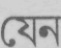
যেন
